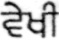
ਵੇਖੀ
